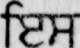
ਇਸ
